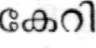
കേറി
